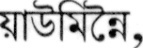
য়াউমিন্নৈ,
